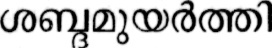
ശബ്ദമുയര്‍ത്തി
